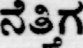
ನೆತ್ತಿಗ
